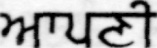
ਆਪਣੀ
